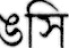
ঙসি
